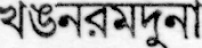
খঙনরমদুনা
